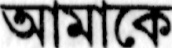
আমাকে
